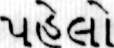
પહેલો
